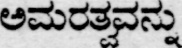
ಅಮರತ್ವವನ್ನು
